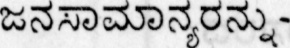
ಜನಸಾಮಾನ್ಯರನ್ನು.
